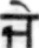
ਜੇ
